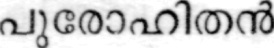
പുരോഹിതന്‍
